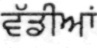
ਵੱਡੀਆਂ
